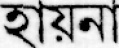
হায়না
